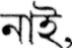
নাই,
